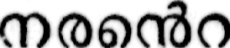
നരന്റെ
